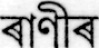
ৰাণীৰ
